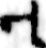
ન
